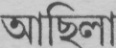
আছিলা
